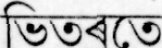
ভিতৰতে
